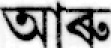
আৰু
